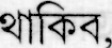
থাকিব,
